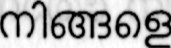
നിങ്ങളെ
